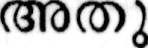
അതു
